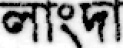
লাংদা
